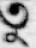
তু
